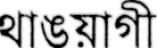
থাঙয়াগী
